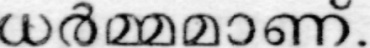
ധര്‍മ്മമാണ്.
